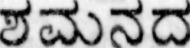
ಶಮನದ
